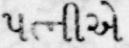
પત્નીએ
